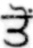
ਤੋਂ
